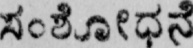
ಸಂಶೋಧನೆ
